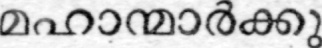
മഹാന്മാര്‍ക്കു
